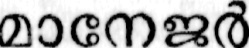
മാനേജര്‍
